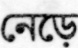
নেড়ে
